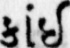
કાંઈ
